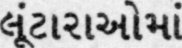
લૂંટારાઓમાં
